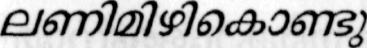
ലണിമിഴികൊണ്ടു
